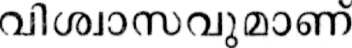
വിശ്വാസവുമാണ്
